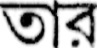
তার
